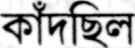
কাঁদছিল
